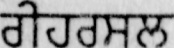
ਰੀਹਰਸਲ
